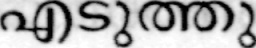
എടുത്തു
